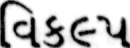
વિકલ્પ
